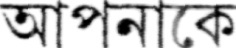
আপনাকে
